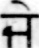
ਜੇ
